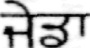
ਜੇਡਾ
